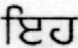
ਇਹ
